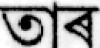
তাৰ
